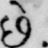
છે.
